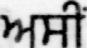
ਅਸੀਂ
